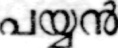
പയ്യന്‍
